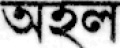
অহল
